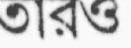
তারও
